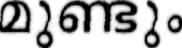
മുണ്ടും
